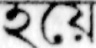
হয়ে
